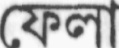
ফেলা
